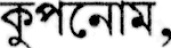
কুপনোম,
